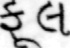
ફૂલ
